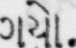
ગયો.
